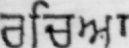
ਰਚਿਆ
